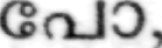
പോ,
